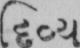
દિવ્ય
